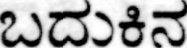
ಬದುಕಿನ
